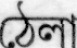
ঠেলা
